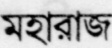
মহারাজ
